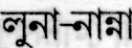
লুনা-নান্না
